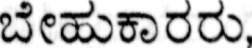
ಬೇಹುಕಾರರು,
